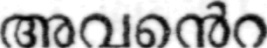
അവന്റെ
